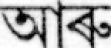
আৰু
